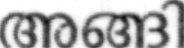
അങ്ങി
